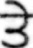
ਤੇ
